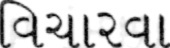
વિચારવા
